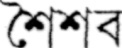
শৈশব
